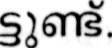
ട്ടുണ്ട്.
